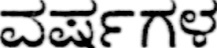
ವರ್ಷಗಳ
